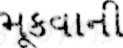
મૂકવાની
